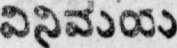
ವಿನಿಮಯ
